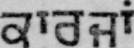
ਕਾਰਜਾਂ
